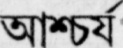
আশ্চর্য
